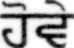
ਹੋਵੇ
